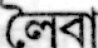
লৈবা
